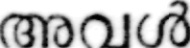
അവള്‍
